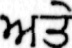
ਅਤੇ
